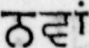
ਨਵਾਂ
